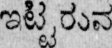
ಇಟ್ಟಿರುವ
